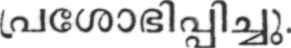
പ്രശോഭിപ്പിച്ചു.
